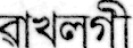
ৱাখলগী
